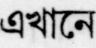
এখানে
